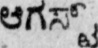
ಆಗಸ್ಟ್
